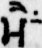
ਮੈਂ
